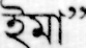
ইমা”
